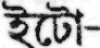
ইটো-
